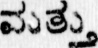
ಮತ್ತು
